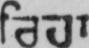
ਰਿਹਾ
